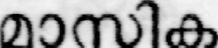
മാസിക
